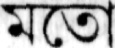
মতো
